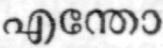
എന്തോ
